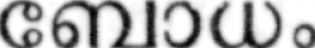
ബോധം
